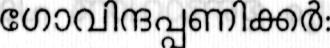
ഗോവിന്ദപ്പണിക്കര്‍:
